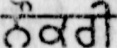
ਨੌਕਰੀ
